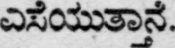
ಎಸೆಯುತ್ತಾನೆ.
